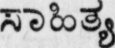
ಸಾಹಿತ್ಯ
